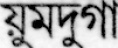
য়ুমদুগা
